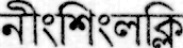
নীংশিংলক্লি
